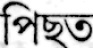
পিছত
